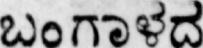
ಬಂಗಾಳದ
